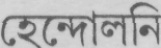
হেন্দোলনি
